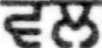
ਵਲ
